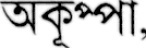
অকূপ্পা,
